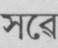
সৱে
